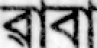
ৱাবা
